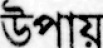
উপায়
